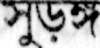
সুড়ঙ্গ
